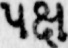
પક્ષ
